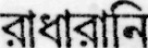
রাধারানি
